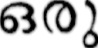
ഒരു
